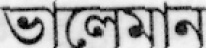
ভালেমান
